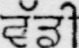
ਵੱਡੀ
